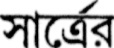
সার্ত্রের
